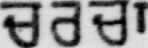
ਚਰਚਾ
